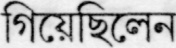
গিয়েছিলেন
